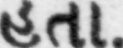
હતા.
